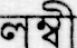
লম্বী
